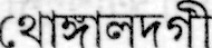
থোঙ্গালদগী
